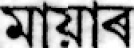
মায়াৰ
